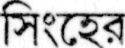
সিংহের
